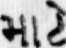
માટે
